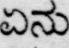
ಏನು
